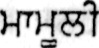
ਮਾਮੂਲੀ
